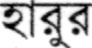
হারুর
